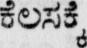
ಕೆಲಸಕ್ಕೆ
